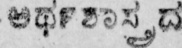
ಅರ್ಥಶಾಸ್ತ್ರದ
